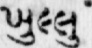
ખુલ્લું
